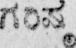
ಗರಿಷ್ಟ
